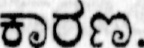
ಕಾರಣ.
